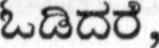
ಓಡಿದರೆ,
